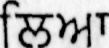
ਲਿਆ
